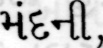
મંદની,
